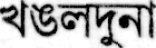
খঙলদুনা
